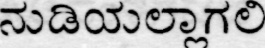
ನುಡಿಯಲ್ಲಾಗಲಿ
